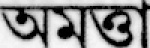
অমত্তা
